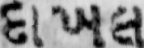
દાખલ
